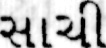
સાચી
